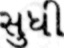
સુધી
